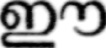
ഈ
